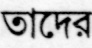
তাদের
